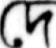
দে
